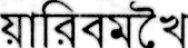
য়ারিবমখৈ
